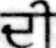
ਦੀ
